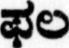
ಫಲ
